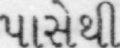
પાસેથી
